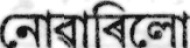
নোৱাৰিলো
